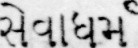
સેવાધર્મ
